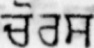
ਚੋਰਸ
